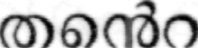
തന്റെ
